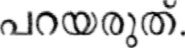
പറയരുത്.
